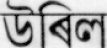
উৰিল
